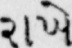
રાખે
